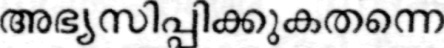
അഭ്യസിപ്പിക്കുകതന്നെ
